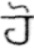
ਹੋ
